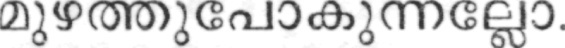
മുഴത്തുപോകുന്നല്ലോ.
